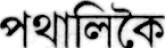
পথালিকৈ
